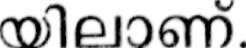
യിലാണ്.
